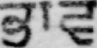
ਭਾਵ
